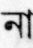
না
